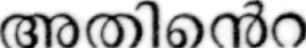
അതിന്റെ
